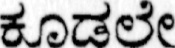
ಕೂಡಲೇ
